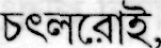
চৎলরোই,
